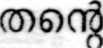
തന്റെ
